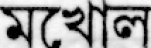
মখোল
